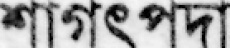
শাগৎপদা
